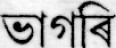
ভাগৰি
